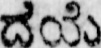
ದಯೆ
